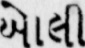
બોલી
